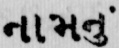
નામનું
